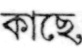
কাছে,
